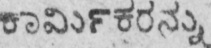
ಕಾರ್ಮಿಕರನ್ನು
